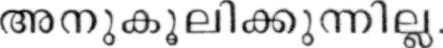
അനുകൂലിക്കുന്നില്ല.
